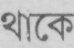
থাকে
